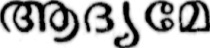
ആദ്യമേ
